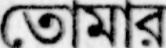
তোমার
